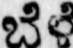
ಬೆಳೆ
